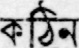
কঠিন
